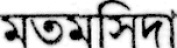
মতমসিদা
